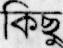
কিছু
